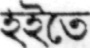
হইতে
